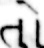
તો
